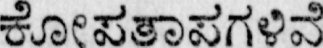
ಕೋಪತಾಪಗಳಿವೆ
